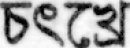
চৎখ্রে
